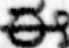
ಈ
